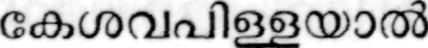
കേശവപിള്ളയാല്‍
